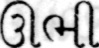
ઊભી
